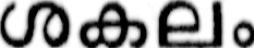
ശകലം
